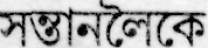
সন্তানলৈকে
